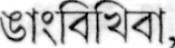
ঙাংবিখিবা,
